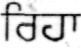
ਰਿਹਾ
